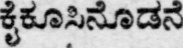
ಕೈಕೂಸಿನೊಡನೆ
